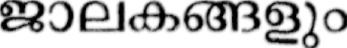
ജാലകങ്ങളും
